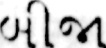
બીજા
